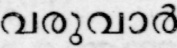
വരുവാര്‍
